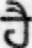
ਹੈ
